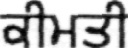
ਕੀਮਤੀ
